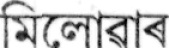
মিলোৱাৰ
